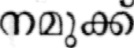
നമുക്ക്
